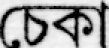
চেকা
